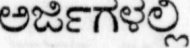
ಅರ್ಜಿಗಳಲ್ಲಿ
